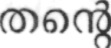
തന്റെ
